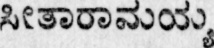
ಸೀತಾರಾಮಯ್ಯ
